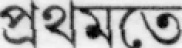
প্রথমতে
